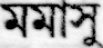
মমাসু
